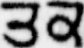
ਤਕ
